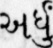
અર્ધું
